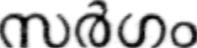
സര്‍ഗം
